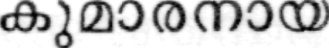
കുമാരനായ
